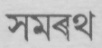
সমৰথ
